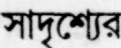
সাদৃশ্যের
